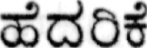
ಹೆದರಿಕೆ
